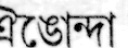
ঐঙোন্দা
